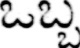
ಒಬ್ಬ
